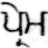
ਪ੍ਰੇਮ
